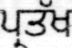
ਪ੍ਰਤੱਖ
